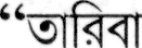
“তারিবা
